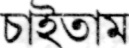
চাইতাম
